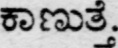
ಕಾಣುತ್ತೆ.
